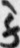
કે
